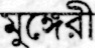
মুঙ্গেরী
